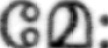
മേ:
